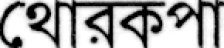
থোরকপা
